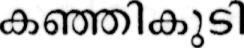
കഞ്ഞികുടി
